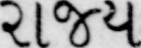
રાજ્ય
